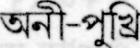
অনী-পুখ্রি
